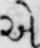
એ
